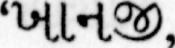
'ખાનજી,
